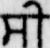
ਸੀ
